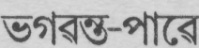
ভগৱন্ত-পাৱে
